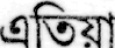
এতিয়া
